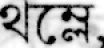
থম্লে,
